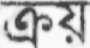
ক্রয়
